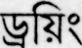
ড্ৰয়িং
